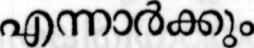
എന്നാര്‍ക്കും
